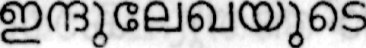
ഇന്ദുലേഖയുടെ
